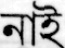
নাই
